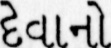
દેવાનો
